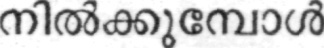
നില്‍ക്കുമ്പോള്‍
